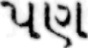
પણ
